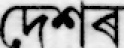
দেশৰ
